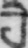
ਹੈ
